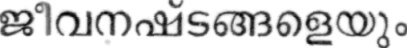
ജീവനഷ്ടങ്ങളെയും
